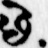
છે.
